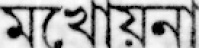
মখোয়না
